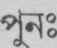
পুনঃ
